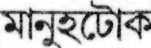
মানুহটোক
